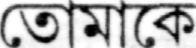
তোমাকে
